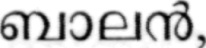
ബാലന്‍,
